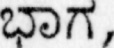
ಭಾಗ,
